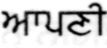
ਆਪਣੀ
